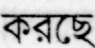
করছে
